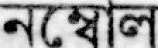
নম্বোল
